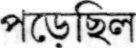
পড়েছিল
